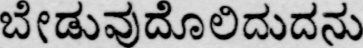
ಬೇಡುವುದೊಲಿದುದನು
